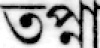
তপ্না
